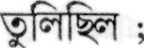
তুলিছিল;
